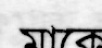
মাকে
